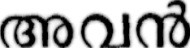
അവന്‍
